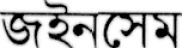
জইনসেম
